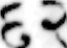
દર
